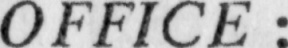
OFFICE:
